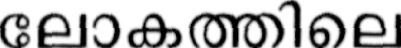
ലോകത്തിലെ
